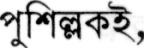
পুশিল্লকই,
